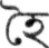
হৈ
